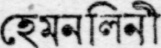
হেমনলিনী
